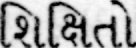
શિક્ષિતો
